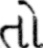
તો
